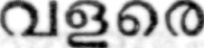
വളരെ
